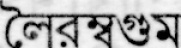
লৈরম্বগুম
